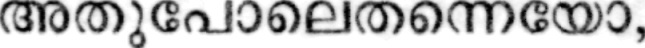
അതുപോലെതന്നെയോ,
